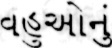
વહુઓનું
